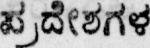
ಪ್ರದೇಶಗಳ
